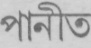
পানীত
